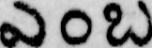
ಎಂಬ
